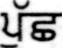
ਪੁੱਛ
